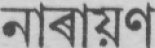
নাৰায়ণ
